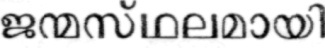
ജന്മസ്ഥലമായി
